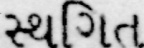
સ્થગિત
